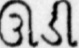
ઊડી
